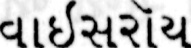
વાઇસરૉય
